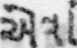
એવાં
